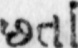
છતાં
